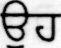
ਉਹ
